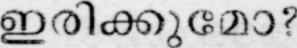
ഇരിക്കുമോ?
